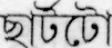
ছাৰ্টটো
